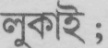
লুকাই;
